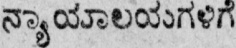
ನ್ಯಾಯಾಲಯಗಳಿಗೆ
